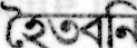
হৈতবনি
